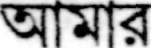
আমার
